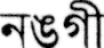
নঙগী
